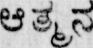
ಆತ್ಮನ
